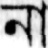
না
